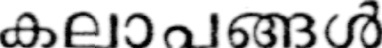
കലാപങ്ങള്‍
